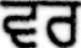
ਵਰ
